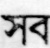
সব
